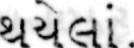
થયેલાં.
